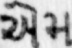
એમ
